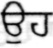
ਉਹ
